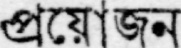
প্রয়োজন
